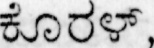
ಕೊರಳ್,
